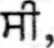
ਸੀ,
